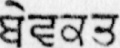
ਬੇਵਕਤ
